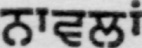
ਨਾਵਲਾਂ
